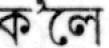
ক'লে
